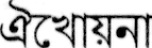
ঐখোয়না
